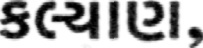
કલ્યાણ,
